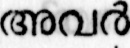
അവര്‍
